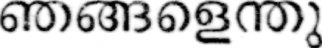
ഞങ്ങളെന്തു
